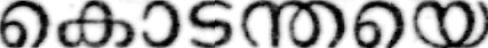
കൊടന്തയെ
